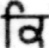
ਕਿ
